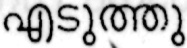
എടുത്തു
